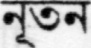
নূতন
